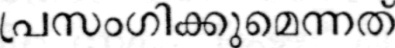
പ്രസംഗിക്കുമെന്നത്
